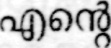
എന്റെ
